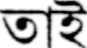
তাই
